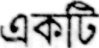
একটি
